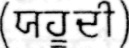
(ਯਹੂਦੀ)
